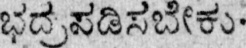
ಭದ್ರಪಡಿಸಬೇಕು.
